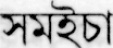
সমইচা
